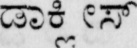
ಡಾಕ್ಲೀಸ್
